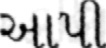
આપી
